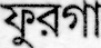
ফুরগা
